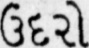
ઉંદરો
